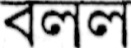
বলল
